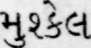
મુશ્કેલ
